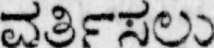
ವರ್ತಿಸಲು
